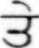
ਤੇ
